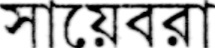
সায়েবরা
